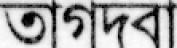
তাগদবা
